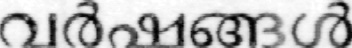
വര്‍ഷങ്ങള്‍
